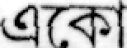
একো
